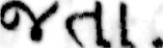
જતા.
